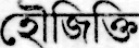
হৌজিক্তি
